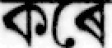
কৰে
